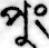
পুং
